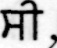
ਸੀ,
